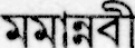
মমান্নবী
